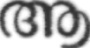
ആ
